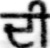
ਦੀ
